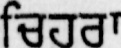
ਚਿਹਰਾ
